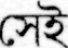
সেই
